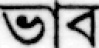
ভাব
